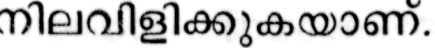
നിലവിളിക്കുകയാണ്.
